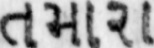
તમારા
